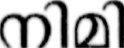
നിമി
